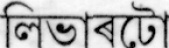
লিভাৰটো
